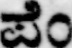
ಪೆಂ
